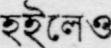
হইলেও
